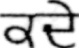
ਕਦੇ
